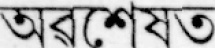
অৱশেষত
